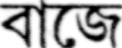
বাজে
